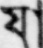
যা
